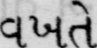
વખતે
